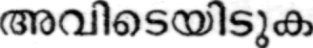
അവിടെയിടുക
